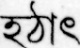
হঠাৎ
